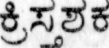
ಕ್ರಿಸ್ತಶಕ
